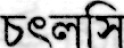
চৎলসি
